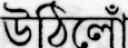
উঠিলোঁ
